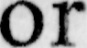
or
